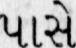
પાસે
